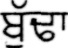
ਬੁੱਢਾ
